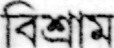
বিশ্রাম
